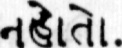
નહોતો.
